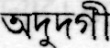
অদুদগী
